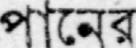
পানের
